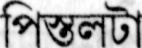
পিস্তলটা
